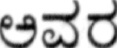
ಅವರ
